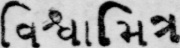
વિશ્વામિત્ર
